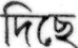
দিছে
